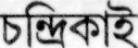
চন্দ্রিকাই
